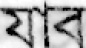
যাব
